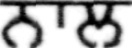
ਨਾਲ
